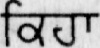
ਕਿਹਾ
